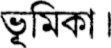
ভূমিকা।
